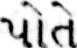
પોતે
